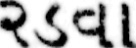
રડવા
